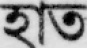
হাত
